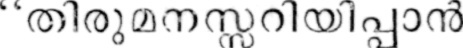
"തിരുമനസ്സറിയിപ്പാന്‍
